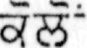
ਕੋਲੋਂ
